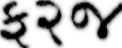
ફરજ
